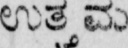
ಉತ್ತಮ
